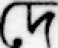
দে
